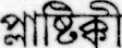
প্লাষ্টিক্কী
